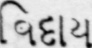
વિદાય
